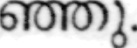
ഞ്ഞു.
